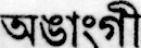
অঙাংগী
